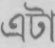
এটা
